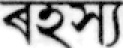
ৰহস্য
